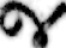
જ
